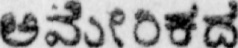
ಅಮೇರಿಕದ
